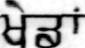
ਖੇਡਾਂ
